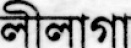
লীলাগা
